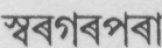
স্বৰগৰপৰা
